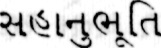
સહાનુભૂતિ
